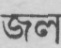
জল
